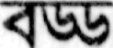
বড্ড
